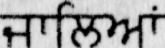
ਜਾਲਿਆਂ
